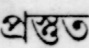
প্রস্তুত
